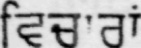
ਵਿਚਾਰਾਂ
